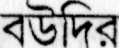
বউদির
